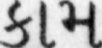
કામ
